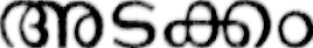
അടക്കം
